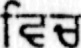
ਵਿਚ
